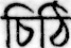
চিঠি
